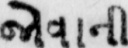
જોવાની
